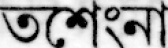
তশেংনা
